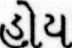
હોય
